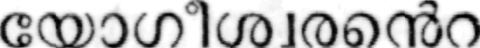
യോഗീശ്വരന്റെ
